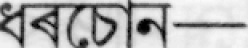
ধৰচোন-
